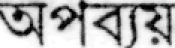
অপব্যয়
